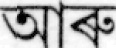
আৰু
